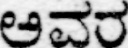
ಅವರ
